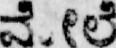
ಮೇಲೆ
